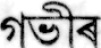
গভীৰ
